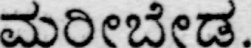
ಮರೀಬೇಡ.
